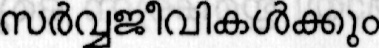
സര്‍വ്വജീവികള്‍ക്കും
